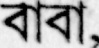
বাবা,
